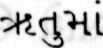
ૠતુમાં
